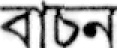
বাচন
